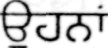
ਉਹਨਾਂ
